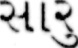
સારુ
